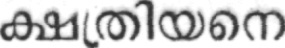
ക്ഷത്രിയനെ
